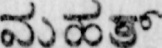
ಮಹತ್
